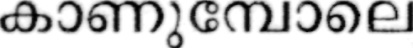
കാണുമ്പോലെ
